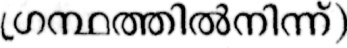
ഗ്രന്ഥത്തില്‍നിന്ന്)
